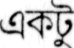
একটু
